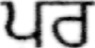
ਪਰ
